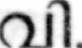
വി.
